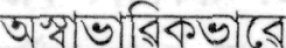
অস্বাভাৱিকভাৱে
